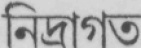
নিদ্ৰাগত
